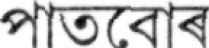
পাতবোৰ
